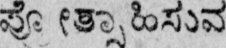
ಪೋತ್ಸಾಹಿಸುವ
